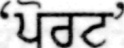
'ਪੋਰਟ'
